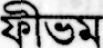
ফীভম
